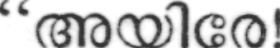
"അയിരേ!
